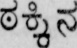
ಠಕ್ಕಿನ
